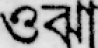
ওঝা
